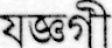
যজ্ঞগী
